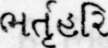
ભર્તૃહરિ
